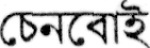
চেনবোই
